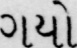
ગયો
